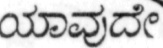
ಯಾವುದೇ
